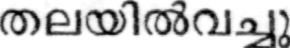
തലയില്‍വച്ചു
